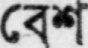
বেশ
